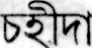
চহীদা
